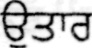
ਉਤਾਰ
